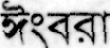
ঈংবরা
